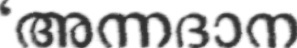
‘അന്നദാന
